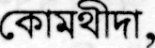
কোমথীদা,
